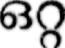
ഒറ്റ
